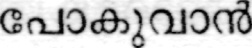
പോകുവാന്‍
